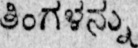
ತಿಂಗಳನ್ನು
